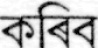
কৰিব
